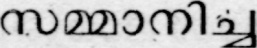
സമ്മാനിച്ച
